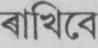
ৰাখিবে
